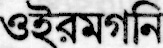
ওইরমগনি
